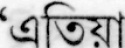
'এতিয়া
